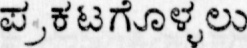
ಪ್ರಕಟಗೊಳ್ಳಲು
